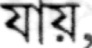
যায়,
